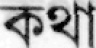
কথা
